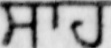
ਸਾਹ
